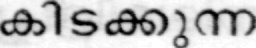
കിടക്കുന്ന
